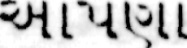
આપણા
